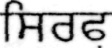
ਸਿਰਫ਼
